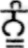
ਨੂੰ
